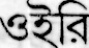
ওইরি
